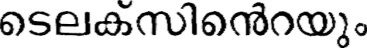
ടെലക്സിന്റെയും
